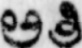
ಅತಿ
